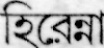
হিরেন্না
